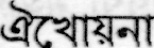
ঐখোয়না
